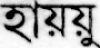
হায়য়ু
